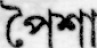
পৈশা
